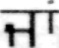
ਜਾਂ
